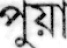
পুয়া
